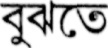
বুঝতে
